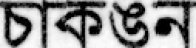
চাকঙন
